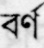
বর্ণ
